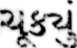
ચૂક્યું
